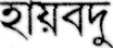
হায়বদু
